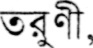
তরুণী,
